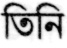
তিনি
